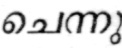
ചെന്നു
